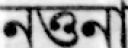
নত্তনা
